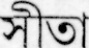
সীতা
